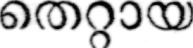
തെറ്റായ
